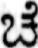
ಚೆ
